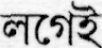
লগেই
